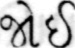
જોઈ
